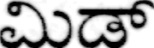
ಮಿಡ್
